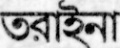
তরাইনা
